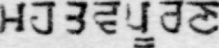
ਮਹਤਵਪੂਰਣ
